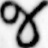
જ
